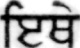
ਇਥੇ
